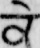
ਕੇ
